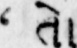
'તો
